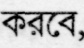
করবে,
